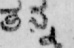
ತನ್ನ
